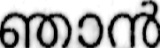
ഞാന്‍
